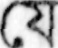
যে
